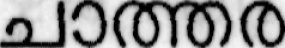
ചാത്തര
